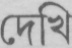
দেখি
